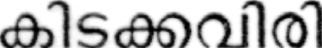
കിടക്കവിരി
